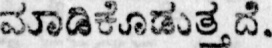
ಮಾಡಿಕೊಡುತ್ತದೆ.
